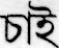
চাই
